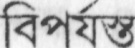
বিপর্যস্ত
